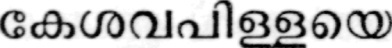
കേശവപിള്ളയെ
